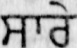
ਸਾਰੇ
